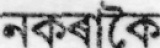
নকৰাকৈ
